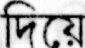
দিয়ে
